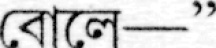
বোলে-"
